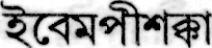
ইবেমপীশক্কা
